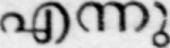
എന്നു
